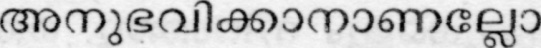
അനുഭവിക്കാനാണല്ലോ
